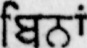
ਬਿਨਾਂ
